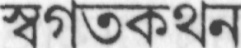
স্বগতকথন
